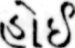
હોઈ
